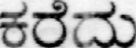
ಕರೆದು
